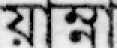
য়াম্না
